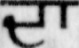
ਦਾ
